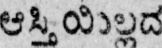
ಆಸ್ತಿಯಿಲ್ಲದ
